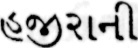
હજીરાની
